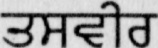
ਤਸਵੀਰ
